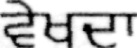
ਵੇਖਦਾ
